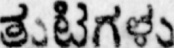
ತುಟಿಗಳು
